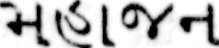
મહાજન
